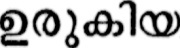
ഉരുകിയ
